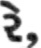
રે,
